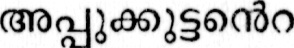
അപ്പുക്കുട്ടന്റെ
